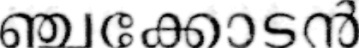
ഞ്ചക്കോടന്‍
